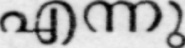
എന്നു
